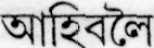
আহিবলৈ
